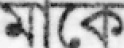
মাকে
